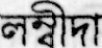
লম্বীদা
